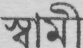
স্বামী
